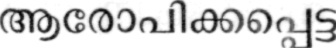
ആരോപിക്കപ്പെട്ട
